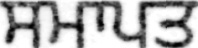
ਸਮਾਪਤ
